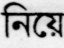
নিয়ে
